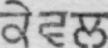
ਕੇਵਲ
